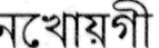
নখোয়গী
